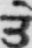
ਤੇ
